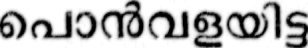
പൊന്‍വളയിട്ട
